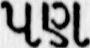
પણ
